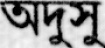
অদুসু
